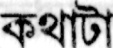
কথাটা
